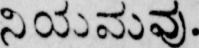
ನಿಯಮವು.
